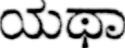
ಯಥಾ
